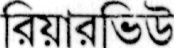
রিয়ারভিউ
